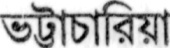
ভট্টাচারিয়া
